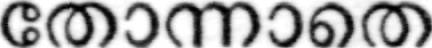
തോന്നാതെ
